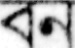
বন
